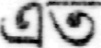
এত
